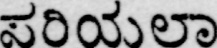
ಪರಿಯಲಾ
